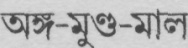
অঙ্গ-মুণ্ড-মাল
